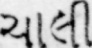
ચાલી
